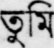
তুমি
